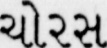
ચોરસ
